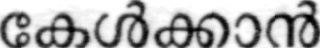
കേള്‍ക്കാന്‍
